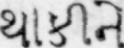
થાકીને
